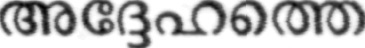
അദ്ദേഹത്തെ
